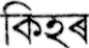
কিহৰ
